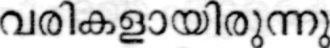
വരികളായിരുന്നു
